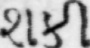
શકી
